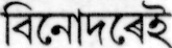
বিনোদৰেই
